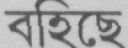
বহিছে
